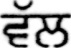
ਵੱਲ
